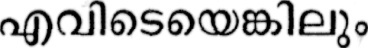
എവിടെയെങ്കിലും
